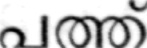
പത്ത്
